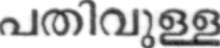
പതിവുള്ള
